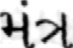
મંત્ર
